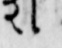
કરી
